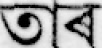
তাৰ
